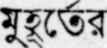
মুহূর্তের
